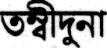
তম্বীদুনা
